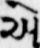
એ
